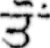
ਤੋਂ
